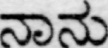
ನಾನು
